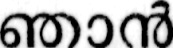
ഞാന്‍
